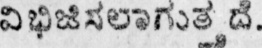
ವಿಭಿಜಿಸಲಾಗುತ್ತದೆ.
